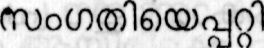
സംഗതിയെപ്പറ്റി
